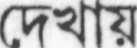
দেখায়
